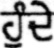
ਹੁੰਦੇ
